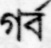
গর্ব
